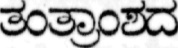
ತಂತ್ರಾಂಶದ
